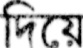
দিয়ে
